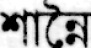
শান্নৈ
